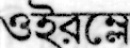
ওইরম্লে
